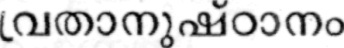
വ്രതാനുഷ്ഠാനം
